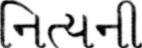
નિત્યની
